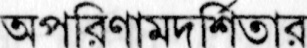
অপরিণামদর্শিতার
